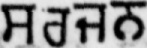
ਸਰਜਨ
